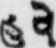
હવે
